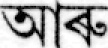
আৰু
